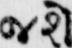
જશે
